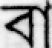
বা
